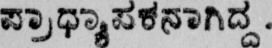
ಪ್ರಾಧ್ಯಾಪಕನಾಗಿದ್ದ.
